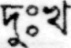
দুঃখ
